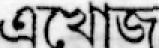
এখোজ
